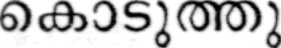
കൊടുത്തു
